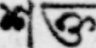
শক্ত
